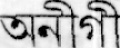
অনীগী
